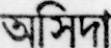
অসিদা
